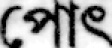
পোৎ
